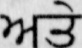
ਅਤੇ
